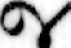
જ
